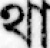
থা
